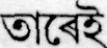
তাৰেই
